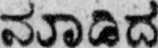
ಮಾಡಿದ
